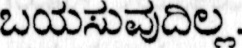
ಬಯಸುವುದಿಲ್ಲ.
